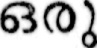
ഒരു
